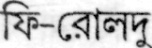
ফি-রোলদু
